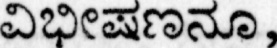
ವಿಭೀಷಣನೂ,
